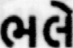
ભલે
